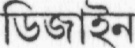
ডিজাইন
